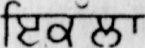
ਇਕੱਲਾ
